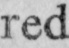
red
